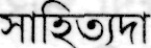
সাহিত্যদা
